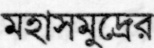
মহাসমুদ্রের
